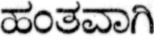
ಹಂತವಾಗಿ
